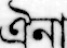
ঐনা
